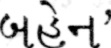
બહેન'
